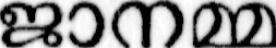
ജാനമ്മ
